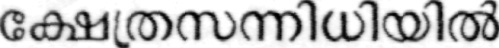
ക്ഷേത്രസന്നിധിയില്‍
